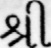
શ્રી
